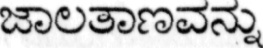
ಜಾಲತಾಣವನ್ನು
